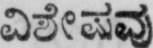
ವಿಶೇಷವು
